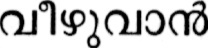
വീഴുവാന്‍
